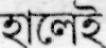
হালেই
